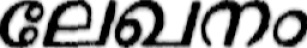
ലേഖനം
